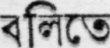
বলিতে
